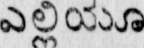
ಎಲ್ಲಿಯೂ
